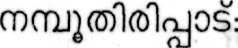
നമ്പൂതിരിപ്പാട്:
